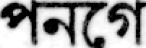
পনগে
